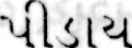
પીડાય
